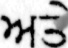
ਅਤੇ
